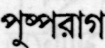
পুষ্পরাগ
